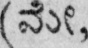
(ಮೇ,
